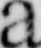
a
